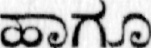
ಹಾಗೂ
